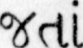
જતાં
